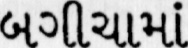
બગીચામાં
